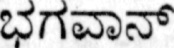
ಭಗವಾನ್
